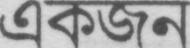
একজন
